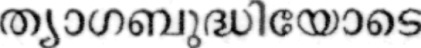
ത്യാഗബുദ്ധിയോടെ
